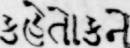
કહેતોકને
